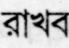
রাখব
